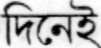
দিনেই
